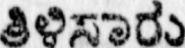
ತಿಳಿಸಾರು
